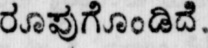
ರೂಪುಗೊಂಡಿದೆ.
